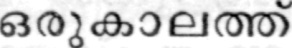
ഒരുകാലത്ത്
